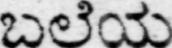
ಬಲೆಯ
